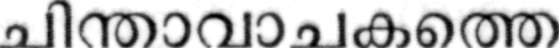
ചിന്താവാചകത്തെ
